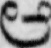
ಆ
